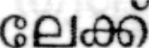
ലേക്ക്
